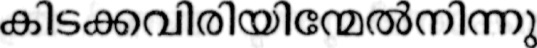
കിടക്കവിരിയിന്മേല്‍നിന്നു
